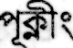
পূ্ক্নীং
